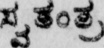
ಸ್ವತ೦ತ್ರ
